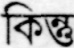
কিন্তু
